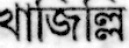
খাজিল্লি
